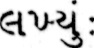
લખ્યું:
